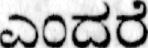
ಎಂದರೆ
